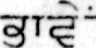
ਭਾਵੇਂ
